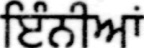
ਇੰਨੀਆਂ
